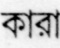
কারা
